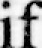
if
